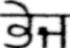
ਭੇਜ
